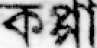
কপ্পা
